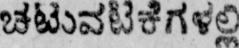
ಚಟುವಟಿಕೆಗಳಲ್ಲಿ
